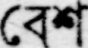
বেশ
